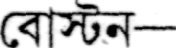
বোস্টন–
